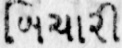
બિચારી
